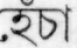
হেঁচা
